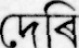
দেৰি
